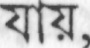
যায়,
